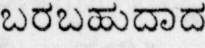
ಬರಬಹುದಾದ
